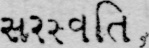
સરસ્વતિ,
